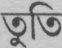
তুতি
